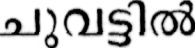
ചുവട്ടില്‍
